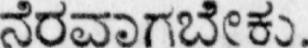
ನೆರೆವಾಗಬೇಕು.
